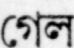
গেল
